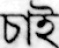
চাই
